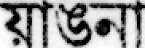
য়াঙনা
